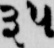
રૂપ
